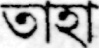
তাহা
